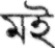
মই
